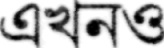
এখনও
